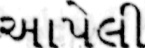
આપેલી
